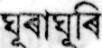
ঘূৰাঘূৰি
